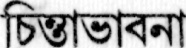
চিন্তাভাবনা
